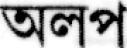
অলপ
